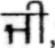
ਜੀ,
